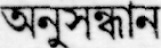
অনুসন্ধান
